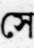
সে
